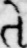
તે
